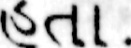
હતા.
